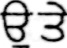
ਉਤੇ
